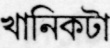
খানিকটা
